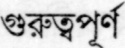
গুরুত্বপূর্ণ
